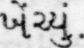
ખેંચ્યું.
